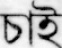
চাই
